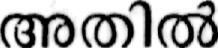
അതില്‍
